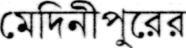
মেদিনীপুরের
